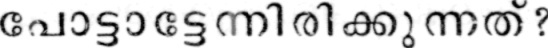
പോട്ടാട്ടേന്നിരിക്കുന്നത്?
